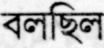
বলছিল
